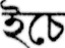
ইচে
